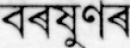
বৰষুণৰ
